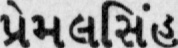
પ્રેમલસિંહ
